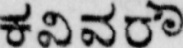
ಕವಿವರೌ
